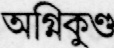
অগ্নিকুণ্ড
